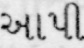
આપી
